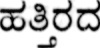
ಹತ್ತಿರದ
